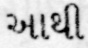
આથી
